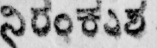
ನಿರಂಕುಶ
